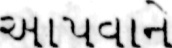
આપવાને
